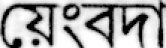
য়েংবদা
